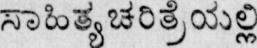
ಸಾಹಿತ್ಯಚರಿತ್ರೆಯಲ್ಲಿ
